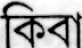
কিবা
